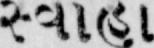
સ્વાહા
